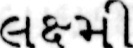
લક્ષ્મી
